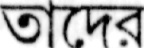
তাদের
